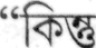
"কিন্তু
